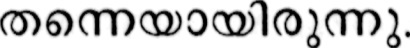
തന്നെയായിരുന്നു.
